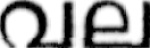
വല
